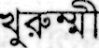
খুরুম্মী
